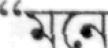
"মনে
